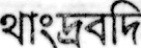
থাংদ্রবদি
